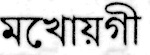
মখোয়গী
